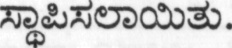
ಸ್ಥಾಪಿಸಲಾಯಿತು.
